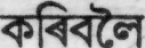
কৰিবলৈ
